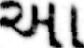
આ
